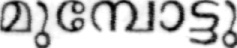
മുമ്പോട്ടു
